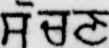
ਸੋਚਣ
